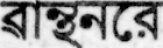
ৱান্থনরে
